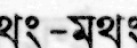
থং মথং
